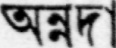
অন্নদা
